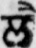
ਲੈ
